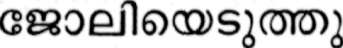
ജോലിയെടുത്തു
